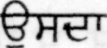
ਉਸਦਾ
